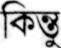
কিন্তু
